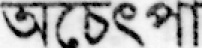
অচেৎপা
